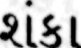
શંકા
